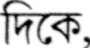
দিকে,
